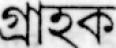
গ্রাহক
